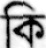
কি
